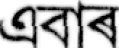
এবাৰ
